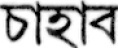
চাহাব
